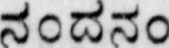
ನಂದನಂ
